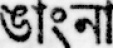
ঙাংনা
